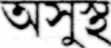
অসুস্থ
